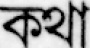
কথা
